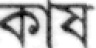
কাষ
